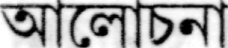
আলোচনা
